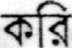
করি
